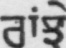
ਰਾਂਝੇ
